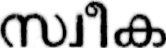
സ്വീക
